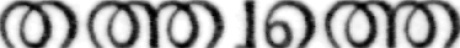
തത്ത്വത്തെ
